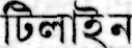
টিলাইন
